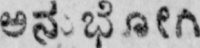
ಅನುಭೋಗ
